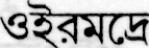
ওইরমদ্রে
